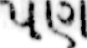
પણ
